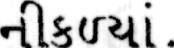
નીકળ્યાં.
